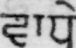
ਵਾਧੇ
